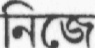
নিজে
